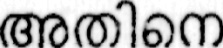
അതിനെ
